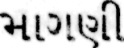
માગણી
